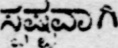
ಸ್ಪಷ್ಟವಾಗಿ
